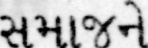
સમાજને
